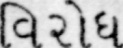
વિરોધ
